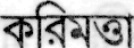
করিমত্তা
